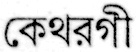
কেথরগী
